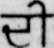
ਦੀ
